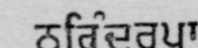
ਨਰਿੰਦਰਪਾ
